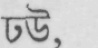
ঢউ,
